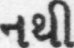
નથી
